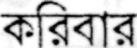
করিবার
